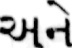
અને
